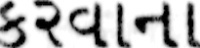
કરવાના
